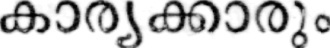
കാര്യക്കാരും
